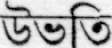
উভতি
